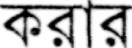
করার
